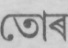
তোৰ
